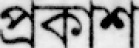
প্রকাশ
